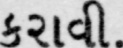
કરાવી.
